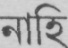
নাহি
